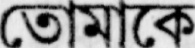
তোমাকে
